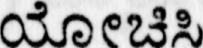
ಯೋಚಿಸಿ
